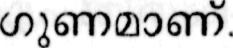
ഗുണമാണ്.
